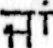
ਜਾਂ
